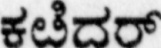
ಕೞದರ್
